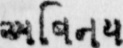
અવિનય
